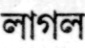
লাগল
